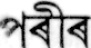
পৰীৰ
